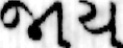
જાય
